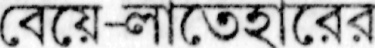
বেয়ে-লাতেহারের
